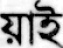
য়াই
